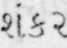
શંકર
